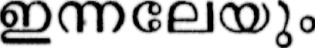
ഇന്നലേയും
